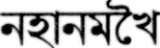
নহানমখৈ
